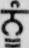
ਨੂੰ
